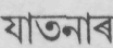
যাতনাৰ
